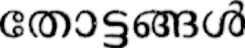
തോട്ടങ്ങള്‍
